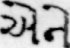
એને
